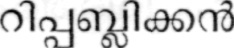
റിപ്പബ്ലിക്കന്‍
